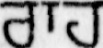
ਰਾਹ
